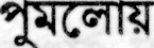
পুমলোয়
